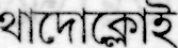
থাদোক্লোই
